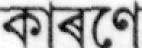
কাৰণে
